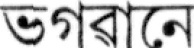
ভগৱানে
